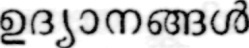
ഉദ്യാനങ്ങള്‍
